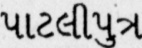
પાટલીપુત્ર
